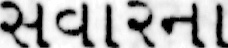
સવારના
